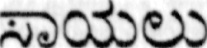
ಸಾಯಲು
